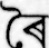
ৰৈ
